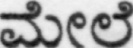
ಮೇಲೆ
